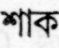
শাক
